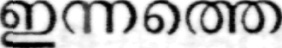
ഇന്നത്തെ
